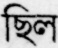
ছিল
